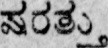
ಷರತ್ತು
